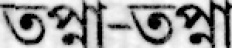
তপ্না-তপ্না
